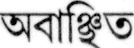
অবাঞ্ছিত
